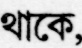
থাকে,
